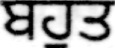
ਬਹੁਤ
